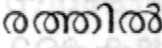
രത്തില്‍
